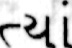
ત્યાં
